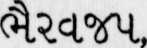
ભૈરવજપ.
